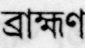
ব্রাহ্মণ
